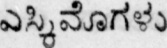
ಎಸ್ಕಿಮೊಗಳು
